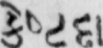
કેષ્ટાદા
